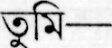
তুমি-
